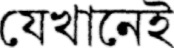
যেখানেই
